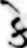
કે
